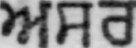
ਅਸਰ
